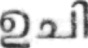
ഉചി
